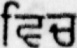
ਵਿਚ
